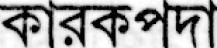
কারকপদা
